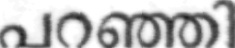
പറഞ്ഞി
